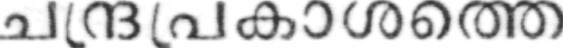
ചന്ദ്രപ്രകാശത്തെ
